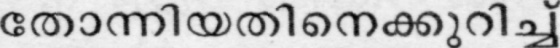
തോന്നിയതിനെക്കുറിച്ച്
